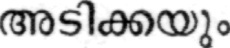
അടിക്കയും
